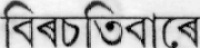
বিৰচতিবাৰে
